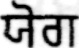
ਯੋਗ
